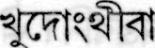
খুদোংথীবা
